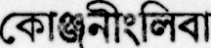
কোঞ্জনীংলিবা
